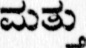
ಮತ್ತು
